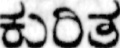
ಕುರಿತ
